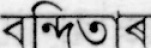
বন্দিতাৰ
